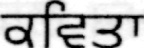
ਕਵਿਤਾ
